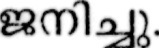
ജനിച്ചു.
